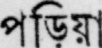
পড়িয়া
